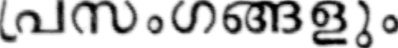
പ്രസംഗങ്ങളും
